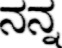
ನನ್ನ
